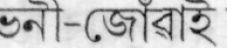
ভনী-জোঁৱাই
